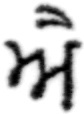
ਐ
